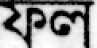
ফল
